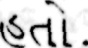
હતો.
